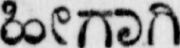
ಹೀಗಾಗಿ
